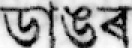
ডাঙৰ
